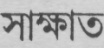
সাক্ষাত
